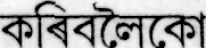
কৰিবলৈকো
